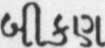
બીકણ
